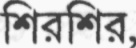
শিরশির,
